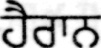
ਹੈਰਾਨ
